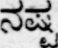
ನಷ್ಟ
